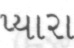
પ્યારા
